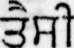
ਤੈਸੀ
